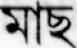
মাছ
